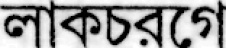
লাকচরগে
